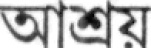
আশ্রয়
